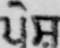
ਪੇਸ਼
